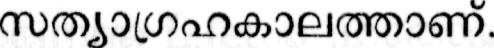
സത്യാഗ്രഹകാലത്താണ്.
